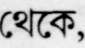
থেকে,
